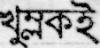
খুম্লকই
